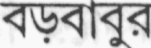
বড়বাবুর
